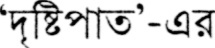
‘দৃষ্টিপাত’-এর
